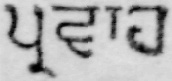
ਪ੍ਰਵਾਹ
